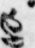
હું
